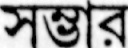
সম্ভার
